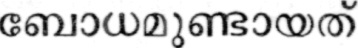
ബോധമുണ്ടായത്
